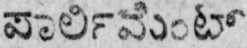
ಪಾರ್ಲಿಮೆಂಟ್
